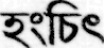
হংচিৎ
